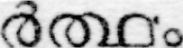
ര്‍ത്ഥം
